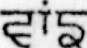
ਵਾਂਙ
